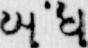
બંધ
